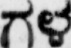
ಗಳ
